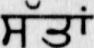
ਸੱਤਾਂ
